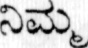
ನಿಮ್ಮ
